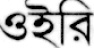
ওইরি
